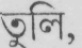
তুলি,
